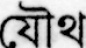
যৌথ
